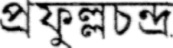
প্রফুল্লচন্দ্র
